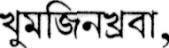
খুমজিনখ্রবা,
